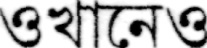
ওখানেও
